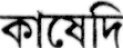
কাষেদি
